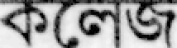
কলেজ
